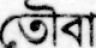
তৌবা
